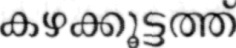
കഴക്കൂട്ടത്ത്
